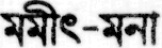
মমীৎ-মনা
